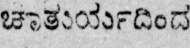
ಚಾತುರ್ಯದಿಂದ
